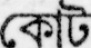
কোট
